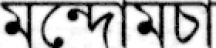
মন্দোমচা
